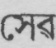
সেৱ
